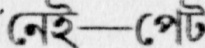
নেই-পেট
